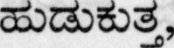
ಹುಡುಕುತ್ತ,
